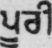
ਪੂਰੀ
